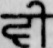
ਵੀ
